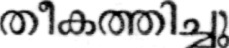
തീകത്തിച്ചു
